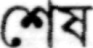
শেষ
